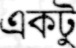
একটু
